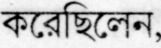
করেছিলেন,
